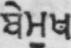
ਬੇਮੁਖ
